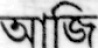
আজি
